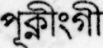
পূক্নীংগী
